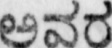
ಅವರ
